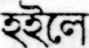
হইলে
